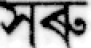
সৰু
